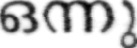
ഒന്നു
